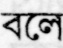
বলে
